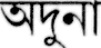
অদুনা
